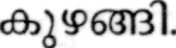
കുഴങ്ങി.
